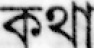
কথা
